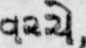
વચ્ચે,
